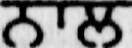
ਨਾਲ
